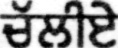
ਚੱਲੀਏ
